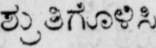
ಶ್ರುತಿಗೊಳಿಸಿ
